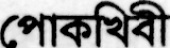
পোকখিবী
